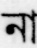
না
